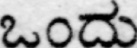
ಒ೦ದು
